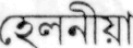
হেলনীয়া
